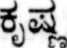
ಕೃಷ್ಣ
